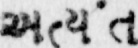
અત્યંત
